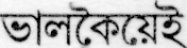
ভালকৈয়েই
